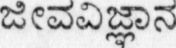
ಜೀವವಿಜ್ಞಾನ
